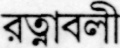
রত্নাবলী
